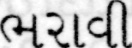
ભરાવી
